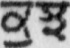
ਕੁਝ
